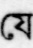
যে
